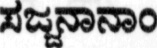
ಸಜ್ಜನಾನಾಂ
